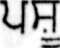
ਪਸ਼ੂ
